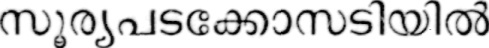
സൂര്യപടക്കോസടിയില്‍
